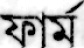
ফার্ম
